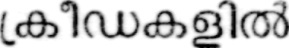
ക്രീഡകളില്‍
